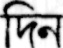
দিন
